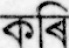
কৰি
